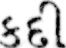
કદી
